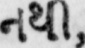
નથી,
